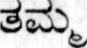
ತಮ್ಮ
